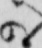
જે
